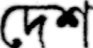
দেশ
